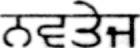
ਨਵਤੇਜ
